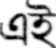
এই
